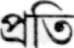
প্রতি
